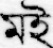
মই
